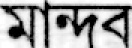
মান্দব
